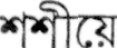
শশীয়ে
